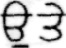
ਉਤੇ
